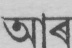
আৰ
